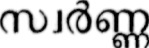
സ്വര്‍ണ്ണ
